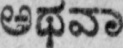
ಅಥವಾ
